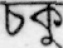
চকু
